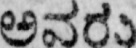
ಅವರು
